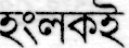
হংলকই
